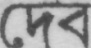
দেব
